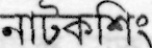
নাটকশিং
